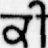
ਕੀ
